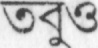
তবুও
